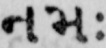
નમઃ
